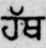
ਹੱਥ
